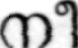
നീ
